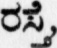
ರಸ್ತೆ,
